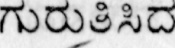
ಗುರುತಿಸಿದ
